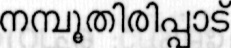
നമ്പൂതിരിപ്പാട്
